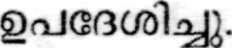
ഉപദേശിച്ചു.
